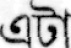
এটা
